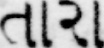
તારા
